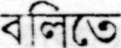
বলিতে
